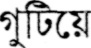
গুটিয়ে
